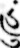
હું
